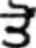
ਤੋਂ
